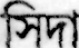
সিদা
